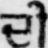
ਦੀ
